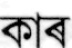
কাৰ
